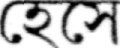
হেসে
